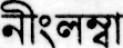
নীংলম্বা
